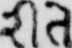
રીતે
